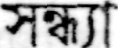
সন্ধ্যা
